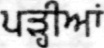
ਪੜ੍ਹੀਆਂ
